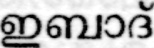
ഇബാദ്
